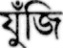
যুঁজি
